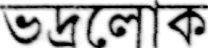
ভদ্রলোক
